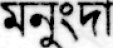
মনুংদা
